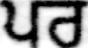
ਪਰ
